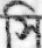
সি
